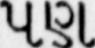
પણ
